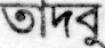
তাদবু
